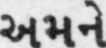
અમને
